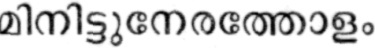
മിനിട്ടുനേരത്തോളം
